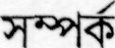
সম্পর্ক
